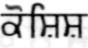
ਕੋਸ਼ਿਸ
